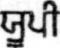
ਯੂਪੀ
